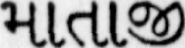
માતાજી
